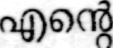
എന്റെ
